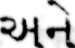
અને
